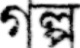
গল্প
